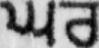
ਘਰ
